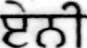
ਏਨੀ
